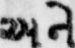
અને
